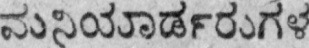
ಮನಿಯಾರ್ಡರುಗಳ
